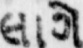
લાગે
